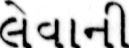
લેવાની
